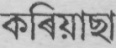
কৰিয়াছা
